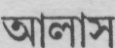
আলাস
